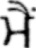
ਮੈਂ
